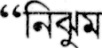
“নিঝুম
